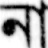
না
